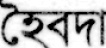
হৈবদা
